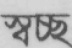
স্বচ্ছ
